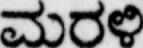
ಮರಳಿ
